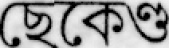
ছেকেণ্ড
